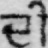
ਦੀ
